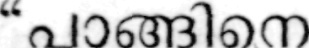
“പാങ്ങിനെ
